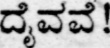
ದೈವವೆ!
